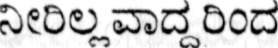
ನೀರಿಲ್ಲವಾದ್ದರಿಂದ
